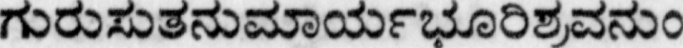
ಗುರುಸುತನುಮಾರ್ಯಭೂರಿಶ್ರವನುಂ
